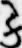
કે
